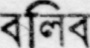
বলিব
